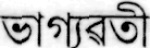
ভাগ্যৱতী
